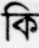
কি
